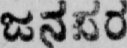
ಜನಪರ
